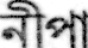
নীপা
